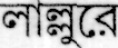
লাল্লুরে
